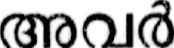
അവര്‍
